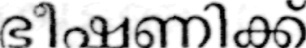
ഭീഷണിക്ക്
